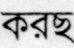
করছ
